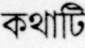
কথাটি
